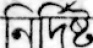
নিৰ্দিষ্ট
